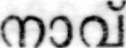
നാവ്
